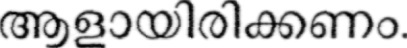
ആളായിരിക്കണം.
